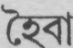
হৈবা
